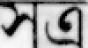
সত্র
